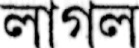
লাগল
